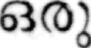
ഒരു
